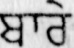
ਬਾਰੇ
